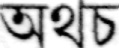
অথচ
